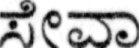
ಸೇವಾ
